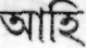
আহি
